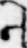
ને
